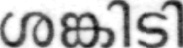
ശങ്കിടി
